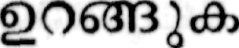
ഉറങ്ങുക
